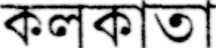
কলকাতা
